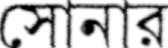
সোনার
